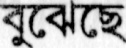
বুঝেছে
